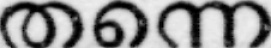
തന്നെ
